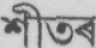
শীতৰ
